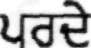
ਪਰਦੇ
